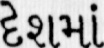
દેશમાં
